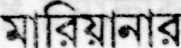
মারিয়ানার
